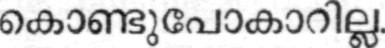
കൊണ്ടുപോകാറില്ല.
